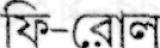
ফি-রোল
